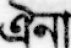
ঐনা
